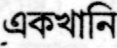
একখানি
